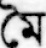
মৈ
